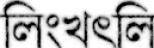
লিংখৎলি
